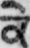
ਕੇ
